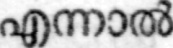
എന്നാല്‍
